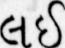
લઈ
